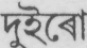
দুইৰো
